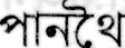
পানথৈ
